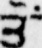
ਤੋਂ
